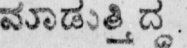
ಮಾಡುತ್ತಿದ್ದ.
